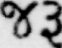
જરૂ
